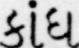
કાંધ
